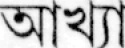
আখ্যা
